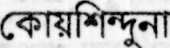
কোয়শিন্দুনা
